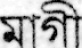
মাগী
